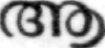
ആ
